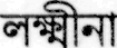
লক্ষ্মীনা
